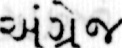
અંગ્રેજ
